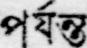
পর্যন্ত
